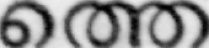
ത്തെ
